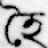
হৈ
